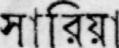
সারিয়া
